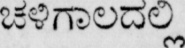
ಚಳಿಗಾಲದಲ್ಲಿ
